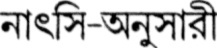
নাৎসি-অনুসারী
